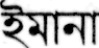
ইমানা
